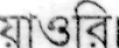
য়াওরি।
